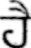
ਹੈ
